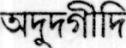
অদুদগীদি
